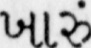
ખારું
